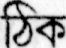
ঠিক
